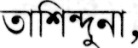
তাশিন্দুনা,
